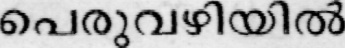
പെരുവഴിയില്‍
